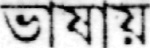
ভাষায়
